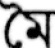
মৈ
